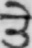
ਤੇ
